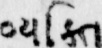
વ્યક્તિ
